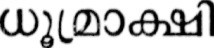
ധൂമ്രാക്ഷി
